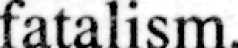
fatalism.
